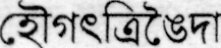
হৌগৎত্রিঙৈদা
